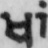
ਖਾਂ
